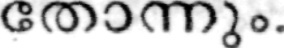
തോന്നും.
